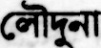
লৌদুনা
